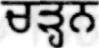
ਚੜ੍ਹਨ
